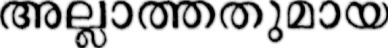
അല്ലാത്തതുമായ
